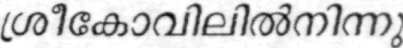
ശ്രീകോവിലില്‍നിന്നു
